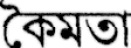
কৈমতা
